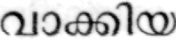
വാക്കിയ
